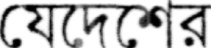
যেদেশের
